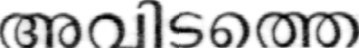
അവിടത്തെ
